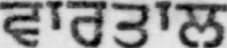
ਵਾਰਤਾਲ
